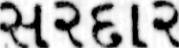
સરદાર
